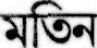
মতিন
